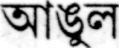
আঙুল
